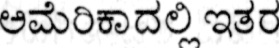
ಅಮೆರಿಕಾದಲ್ಲಿಇತರ
